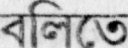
বলিতে
